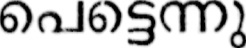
പെട്ടെന്നു
